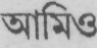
আমিও
